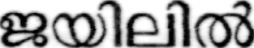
ജയിലില്‍
